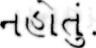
નહોતું.
